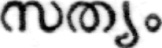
സത്യം
